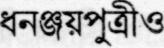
ধনঞ্জয়পুত্রীও
